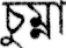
চুম্না
